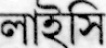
লাইসি
